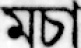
মচা
